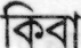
কিবা
